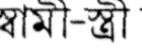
স্বামী-স্ত্রী
